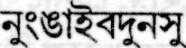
নুংঙাইবদুনসু
